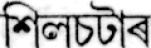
শিলচটাৰ
